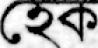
হেক
